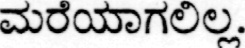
ಮರೆಯಾಗಲಿಲ್ಲ.
